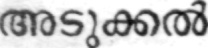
അടുക്കല്‍
